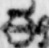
ಈ
